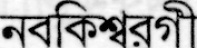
নবকিশ্বরগী
